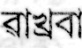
ৱাখ্রবা
